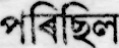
পৰিছিল
